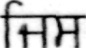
ਜਿਸ
